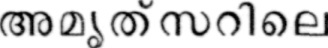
അമൃത്‌സറിലെ
